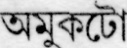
অমুকটো
